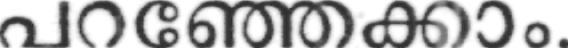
പറഞ്ഞേക്കാം.
